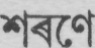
শৰণে
